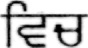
ਵਿਚ
